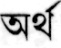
অর্থ
